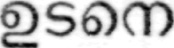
ഉടനെ
